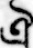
ঐ
